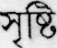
সৃষ্টি
